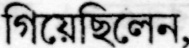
গিয়েছিলেন,
